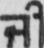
ਜੀ
